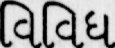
વિવિધ
